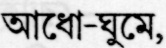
আধো-ঘুমে,
